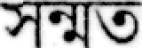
সন্মত
